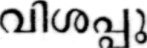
വിശപ്പു
